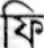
ফি
